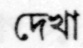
দেখা
